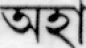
অহা
